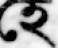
হে
